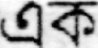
এক
